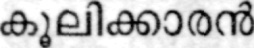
കൂലിക്കാരന്‍
